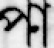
পা
